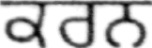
ਕਰਨ
